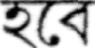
হবে
